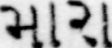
મારા
